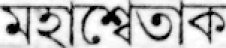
মহাশ্বেতাক
